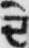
ਦੇ
